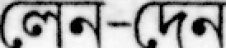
লেন-দেন
